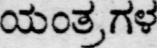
ಯಂತ್ರಗಳ
